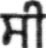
ਸੀ
